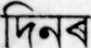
দিনৰ
